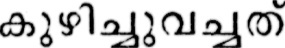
കുഴിച്ചുവച്ചത്
